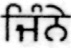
ਜਿੰਨੇ
